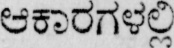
ಆಕಾರಗಳಲ್ಲಿ
